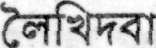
লৈখিদবা
